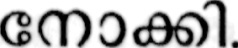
നോക്കി.
